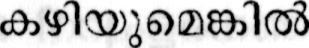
കഴിയുമെങ്കില്‍
